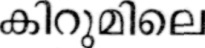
കിറുമിലെ
